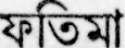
ফতিমা
